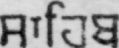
ਸਾਹਿਬ
